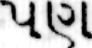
પણ
